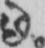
છે.
